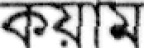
কয়াম
